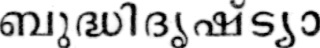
ബുദ്ധിദൃഷ്ട്യാ
